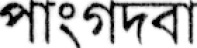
পাংগদবা
